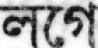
লগে
